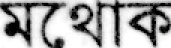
মথোক
